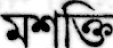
মশক্তি
